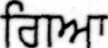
ਗਿਆ
